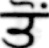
ਤੋਂ
